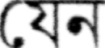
যেন
